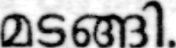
മടങ്ങി.
